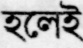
হলেই
